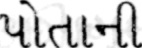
પોતાની
